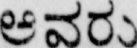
ಅವರು
